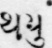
થયું
